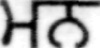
ਮਨ
